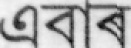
এবাৰ
